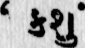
'કશું
